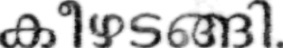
കീഴടങ്ങി.
